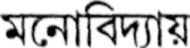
মনোবিদ্যায়
